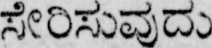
ಸೇರಿಸುವುದು
